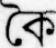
কৈ
